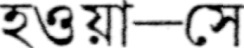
হওয়া–সে
